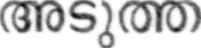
അടുത്ത
